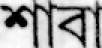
শাবা
